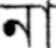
না
